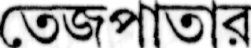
তেজপাতার
